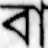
বা
